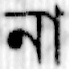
না
